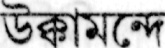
উক্কামন্দে
